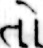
તો
